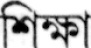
শিক্ষা
